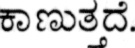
ಕಾಣುತ್ತದೆ.
